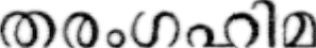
തരംഗഹിമ
